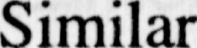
Similar
